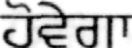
ਹੋਵੇਗਾ
